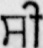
ਸੀ
